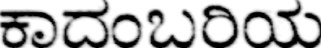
ಕಾದಂಬರಿಯ
